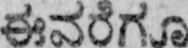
ಈವರೆಗೂ
